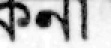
কনা
